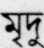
মৃদু
